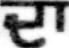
ਦਾ
